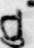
તું
